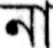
না
